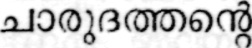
ചാരുദത്തന്റെ
